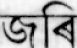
জৰি
